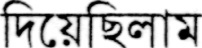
দিয়েছিলাম
